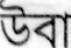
উবা
